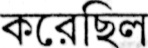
করেছিল
